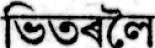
ভিতৰলৈ
